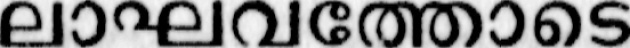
ലാഘവത്തോടെ
